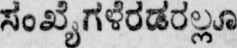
ಸಂಖ್ಯೆಗಳೆರಡರಲ್ಲೂ
